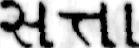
સત્તા
